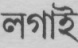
লগাই
